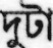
দুটা
